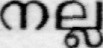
നല്ല
